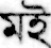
মই
